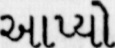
આપ્યો
